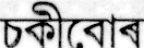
চকীবোৰ
